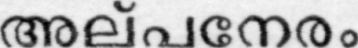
അല്പനേരം
